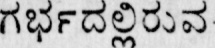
ಗರ್ಭದಲ್ಲಿರುವ
